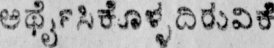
ಅರ್ಥೈಸಿಕೊಳ್ಳದಿರುವಿಕೆ
